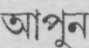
আপুন
